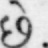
છે.
